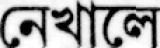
নেখালে
